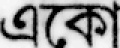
একো
